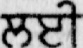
ਲਈ
